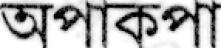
অপাকপা
